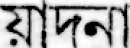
য়াদনা
